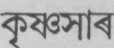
কৃষ্ণসাৰ
